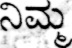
ನಿಮ್ಮ
